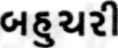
બહુચરી
